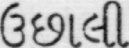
ઉછાલી
